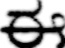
ಈ
